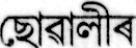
ছোৱালীৰ
